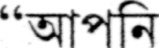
“আপনি
